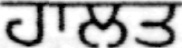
ਹਾਲਤ
